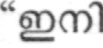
“ഇനി
